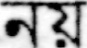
নয়
